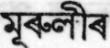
মূৰুলীৰ
